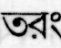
তরং
